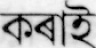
কৰাই
